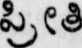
ಪ್ರೀತಿ
